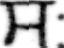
ਸ:
